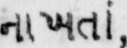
નાખતાં
